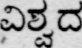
ವಿಶ್ವದ
